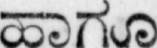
ಹಾಗೂ
